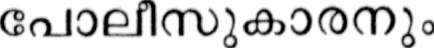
പോലീസുകാരനും
